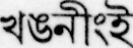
খঙনীংই
